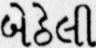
બેઠેલી
